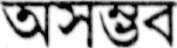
অসম্ভব
